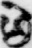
છે
